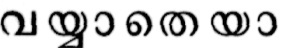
വയ്യാതെയാ
